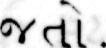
જતો.
